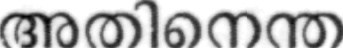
അതിനെന്ത
